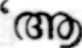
'ആ
